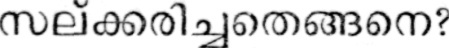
സല്ക്കരിച്ചതെങ്ങനെ?
